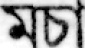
মচা
